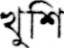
খুশি
